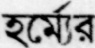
হর্ম্যের
